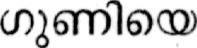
ഗുണിയെ
